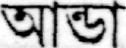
আন্ডা
